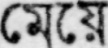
মেয়ে
